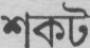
শকট
